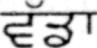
ਵੱਡਾ
